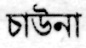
চাউনা
